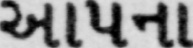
આપના
